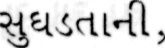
સુઘડતાની,
